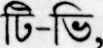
টি-ভি,
